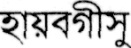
হাযবগীসু
